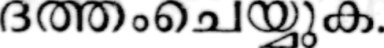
ദത്തംചെയ്യുക.
